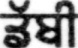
ਡੱਬੀ
